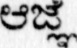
ಆಜ್ಞೆ
